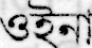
ওইনা
